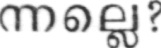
ന്നല്ലെ?
